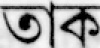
তাক
